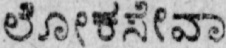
ಲೋಕಸೇವಾ
